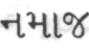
નમાજ
